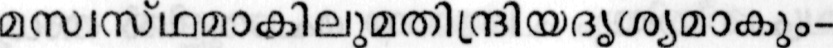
മസ്വസ്ഥമാകിലുമതിന്ദ്രിയദൃശ്യമാകും-
